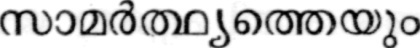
സാമര്‍ത്ഥ്യത്തെയും
